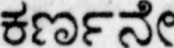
ಕರ್ಣನೇ
